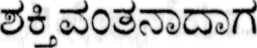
ಶಕ್ತಿವಂತನಾದಾಗ
